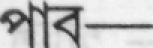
পাব-
